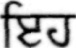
ਇਹ
